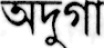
অদুগা
